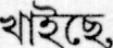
খাইছে,
